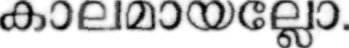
കാലമായല്ലോ.
